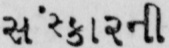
સંસ્કારની
